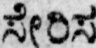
ಸೇರಿಸ
